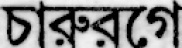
চারুরগে
